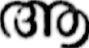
ആ
